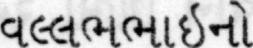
વલ્લભભાઈનો
